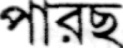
পারছ
